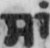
ਸਾਂ
